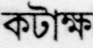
কটাক্ষ
